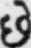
છે
